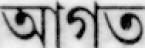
আগত
